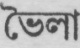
ভৈলা
